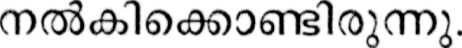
നല്‍കിക്കൊണ്ടിരുന്നു.
